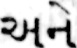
અને
